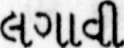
લગાવી
